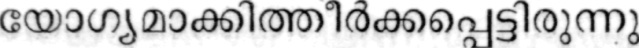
യോഗ്യമാക്കിത്തീര്‍ക്കപ്പെട്ടിരുന്നു
